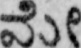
ಮೇ
